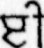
ਈ
